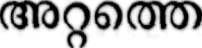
അറ്റത്തെ
